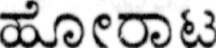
ಹೋರಾಟ
